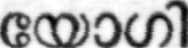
യോഗി
